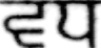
ਵਧ
